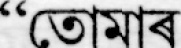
"তোমাৰ
